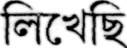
লিখেছি
